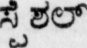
ಸ್ಪೆಶಲ್
